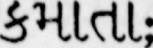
કમાતા;
